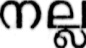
നല്ല
